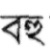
বহু
